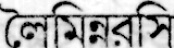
লৈমিন্নরসি
